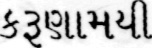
કરૂણામયી
